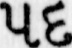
પદ
